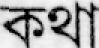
কথা
